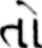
તો
